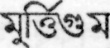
মুর্ত্তিগুম
